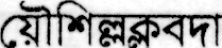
য়ৌশিল্লক্লবদা
